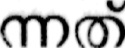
ന്നത്
